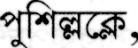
পুশিল্লক্লে,
